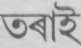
তৰাই
